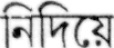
নিদিয়ে
